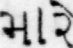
મારે
